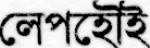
লেপহৌই
